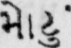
મોટું
